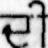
ਦੀ
